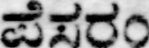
ಪೆಸರಂ
